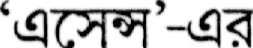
'এসেন্স'-এর
